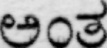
ಅಂತ
